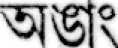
অঙাং
